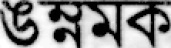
ঙম্নমক
